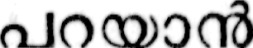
പറയാന്‍
